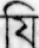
যি
